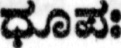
ಧೂಪಃ
